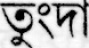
তুংদা
